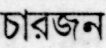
চারজন
